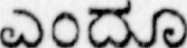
ಎಂದೂ
